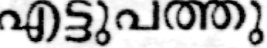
എട്ടുപത്തു
